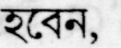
হবেন,
